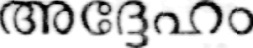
അദ്ദേഹം
